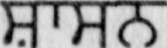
ਸ਼ਾਸਨ
